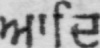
ਆਦਿ
